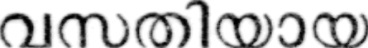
വസതിയായ
